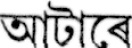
আটাৰে
